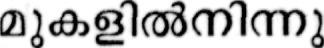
മുകളില്‍നിന്നു
